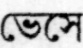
ভেসে
